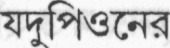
যদুপিওনের
